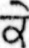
ਕੇ
